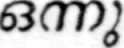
ഒന്നു
